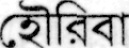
হৌরিবা
